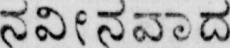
ನವೀನವಾದ
